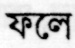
ফলে
